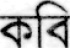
কবি
